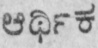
ಆರ್ಥಿಕ
